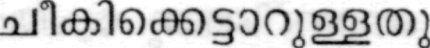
ചീകിക്കെട്ടാറുള്ളതു
